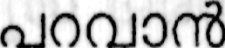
പറവാന്‍
